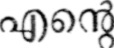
എന്റെ
